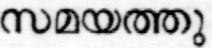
സമയത്തു
